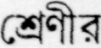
শ্রেণীর
